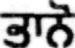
ਭਾਨੋ
